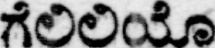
ಗೆಲಿಲಿಯೊ
